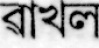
ৱাখল
